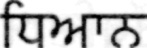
ਧਿਆਨ
